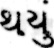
થયું
